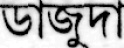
ডাজুদা
